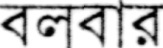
বলবার
